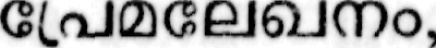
പ്രേമലേഖനം,
